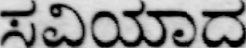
ಸವಿಯಾದ
